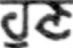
ਹੁਣ
